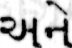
અને
